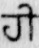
ਹੀ
